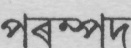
পৰম্পদ
